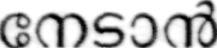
നേടാന്‍
